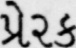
પ્રેરક
